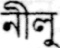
নীলু
